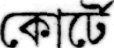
কোর্টে
